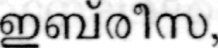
ഇബ്രീസ,
